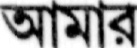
আমার
